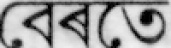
বেৰতে
